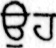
ਉਹ
